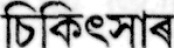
চিকিৎসাৰ
